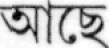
আছে
